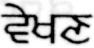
ਵੇਖਣ
